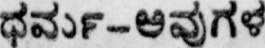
ಧರ್ಮ-ಅವುಗಳ
